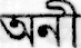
অনী
